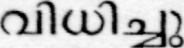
വിധിച്ചു
